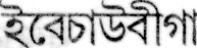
ইবেচাউবীগা
